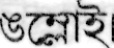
ঙম্লোই।
